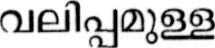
വലിപ്പമുള്ള
